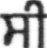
ਸੀ
